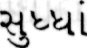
સુધ્ધાં
